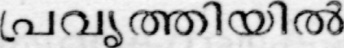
പ്രവൃത്തിയില്‍
